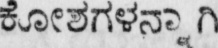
ಕೋಶಗಳನ್ನಾಗಿ
